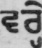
ਵਰ੍ਹੇ
